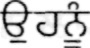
ਉਹਨੂੰ
